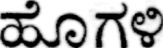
ಹೊಗಳಿ
